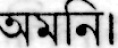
অমনি।
